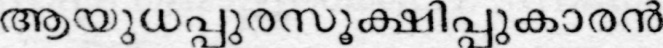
ആയുധപ്പുരസൂക്ഷിപ്പുകാരന്‍
